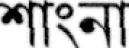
শাংনা
